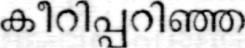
കീറിപ്പറിഞ്ഞ
